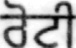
ਰੋਟੀ
